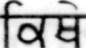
ਕਿਥੇ
